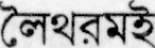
লৈথরমই
